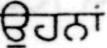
ਉਹਨਾਂ
